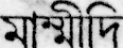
মাম্মীদি
